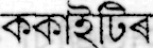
ককাইটিৰ
